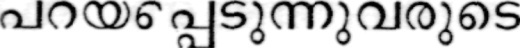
പറയപ്പെടുന്നുവരുടെ
